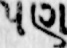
પણ
